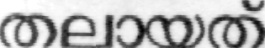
തലായത്
